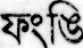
ফংঙি
